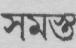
সমস্ত
